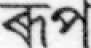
ৰূপ
